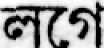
লগে
